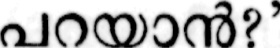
പറയാന്‍?’
